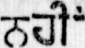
ਨਹੀਂ
